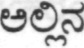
ಅಲ್ಲಿನ
